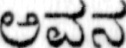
ಅವನ
